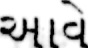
આવે
